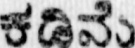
ಕಡಿಮೆ
